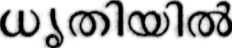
ധൃതിയില്‍
